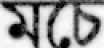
মচে
